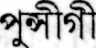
পুন্সীগী
